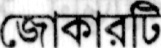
জোকারটি
